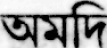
অমদি
